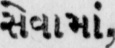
સેવામાં,
